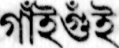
গাঁইগুঁই
